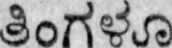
ತಿಂಗಳೂ
